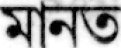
মানত
